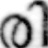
രി
